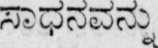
ಸಾಧನವನ್ನು
